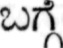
ಬಗ್ಗೆ
